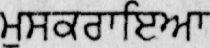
ਮੁਸਕਰਾਇਆ
